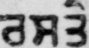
ਰਸਤੇ
